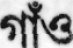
গাঁও
